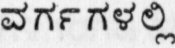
ವರ್ಗಗಳಲ್ಲಿ
